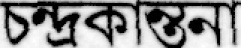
চন্দ্রকান্তনা
